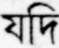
যদি
